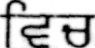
ਵਿਚ
